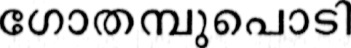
ഗോതമ്പുപൊടി
